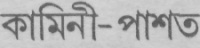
কামিনী-পাশত
